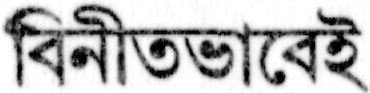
বিনীতভাবেই
